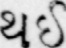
થઈ
